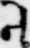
ને
